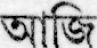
আজি
